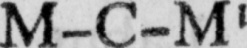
M-C-M
